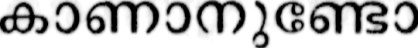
കാണാനുണ്ടോ
